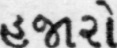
હજારો
